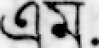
এম.
